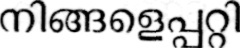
നിങ്ങളെപ്പറ്റി
